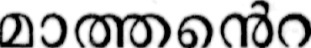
മാത്തന്റെ
